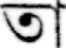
তা
